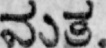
ಮತ.
